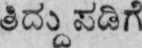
ತಿದ್ದುಪಡಿಗೆ
